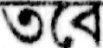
তবে
